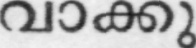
വാക്കു
